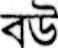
বউ
